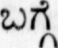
ಬಗ್ಗೆ
